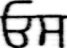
ਓਸ
